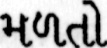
મળતો
